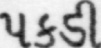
પકડી
